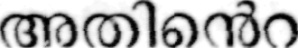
അതിന്റെ
